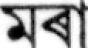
মৰা
